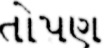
તોપણ
